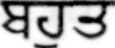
ਬਹੁਤ
